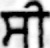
ਸੀ
